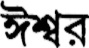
ঈশ্বর
